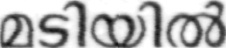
മടിയില്‍
